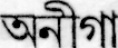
অনীগা
